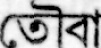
তৌবা
